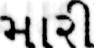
મારી
